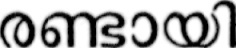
രണ്ടായി
